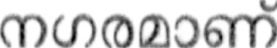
നഗരമാണ്
